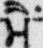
ਮੈਂ
